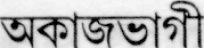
অকাজভাগী
